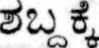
ಶಬ್ದಕ್ಕೆ
